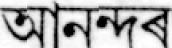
আনন্দৰ
